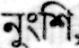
নুংশি,
